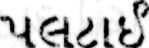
પલટાઈ
